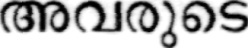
അവരുടെ
